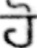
ਹੋ
